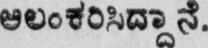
ಅಲಂಕರಿಸಿದ್ದಾನೆ.
